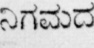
ನಿಗಮದ
